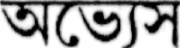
অভ্যেস
